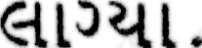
લાગ્યા.
